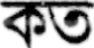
কত
